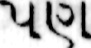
પણ
